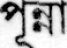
পুন্না
